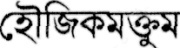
হৌজিকমক্তুম
